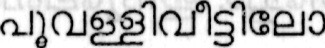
പൂവള്ളിവീട്ടിലോ
